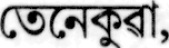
তেনেকুৱা,
